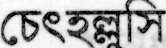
চেৎহল্লুসি
